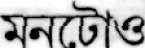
মনটোও
